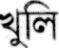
খুলি
